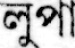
লুপা
